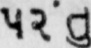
પરંતુ
